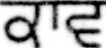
ਕਾਵ
